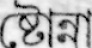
ষ্টোন্না
